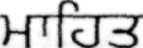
ਮਾਹਿਤ
